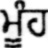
ਮੂੰਹ
